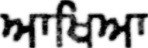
ਆਖਿਆ
